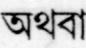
অথবা
